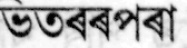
ভিতৰৰপৰা
